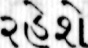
રહેશે
